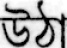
উঠা
